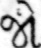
જો
